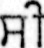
ਸੀ
